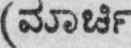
(ಮಾರ್ಚಿ
